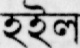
হইল
